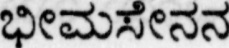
ಭೀಮಸೇನನ
